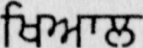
ਖਿਆਲ
